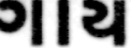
ગાય
